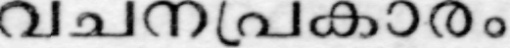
വചനപ്രകാരം
